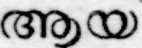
ആയ
